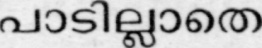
പാടില്ലാതെ
